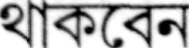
থাকবেন
